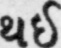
થઈ
